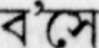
ব'সে
